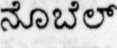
ನೊಬೆಲ್
